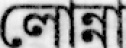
লোন্না
